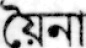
য়ৈনা
